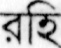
রহি
